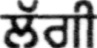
ਲੱਗੀ
